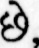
છે,
